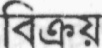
বিক্রয়
